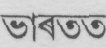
ভাৰতত
